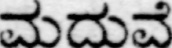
ಮದುವೆ
